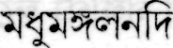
মধুমঙ্গলনদি
